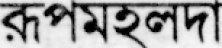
রূপমহলদা
